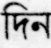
দিন
